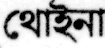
থোইনা
